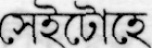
সেইটোহে
